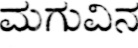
ಮಗುವಿನ
